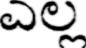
ಎಲ್ಲ
